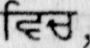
ਵਿਚ,
